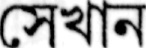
সেখান
